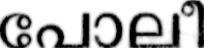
പോലീ
